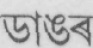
ডাঙৰ
